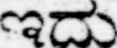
ಇದು
